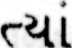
ત્યાં
